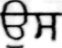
ਉਸ
